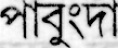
পাবুংদা
